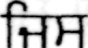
ਜਿਸ
